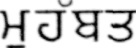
ਮੁਹੱਬਤ
